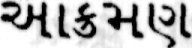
આક્રમણ
